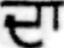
ਦਾ
